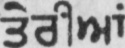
ਤੇਰੀਆਂ
